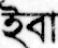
ইবা
